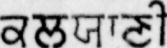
ਕਲਯਾਣੀ
